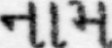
નામ
